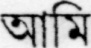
আমি
